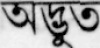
অদ্ভুত
